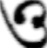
ও
